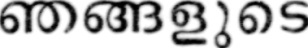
ഞങ്ങളുടെ
